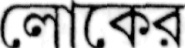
লোকের
